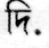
দি.
